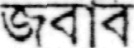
জবাব
